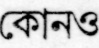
কোনও
